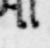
બી
